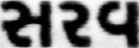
સરવ
